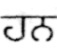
ਹਨ
